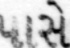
પાસે
